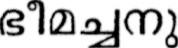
ഭീമച്ചനു
